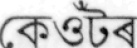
কেওঁটৰ
